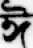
ঈ
